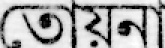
তোয়না
